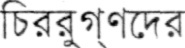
চিররুগ্ণদের
